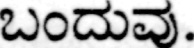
ಬಂದುವು.
